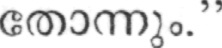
തോന്നും."
